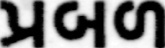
પ્રબળ
